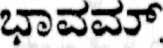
ಭಾವಮ್
